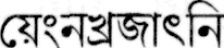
য়েংনখ্রজাৎনি
